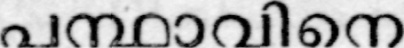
പന്ഥാവിനെ
